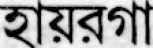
হায়রগা
